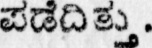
ಪಡೆದಿತ್ತು.
